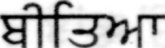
ਬੀਤਿਆ
